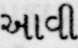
આવી
